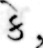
કે,
